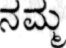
ನಮ್ಮ
